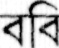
ববি
